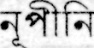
নূপীনি
